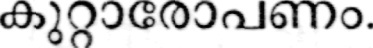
കുറ്റാരോപണം.
